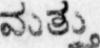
ಮತ್ತು
